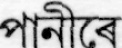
পানীৰে
